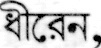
ধীরেন,
